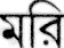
মরি
